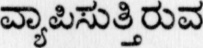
ವ್ಯಾಪಿಸುತ್ತಿರುವ
